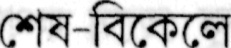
শেষ-বিকেলে
